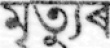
মৃত্যুৰ
